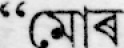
"মোৰ
